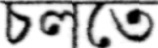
চলতে
